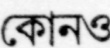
কোনও
